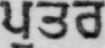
ਪੁਤਰ
